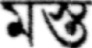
মস্ত
